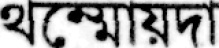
থম্মোয়দা
